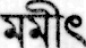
মমীৎ
